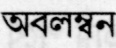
অবলম্বন
